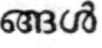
ങ്ങള്‍
